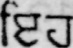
ਇਹ
